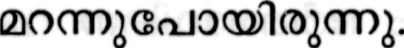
മറന്നുപോയിരുന്നു.
